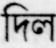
দিল
